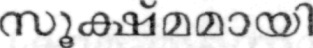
സൂക്ഷ്മമായി
